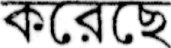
করেছে
